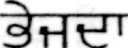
ਭੇਜਦਾ
